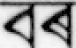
বৰ
